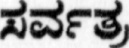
ಸರ್ವತ್ರ
